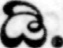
ಡಿ.
